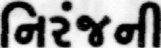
નિરંજની
